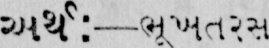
અર્થઃ-ભૂખતરસ
